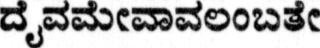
ದೈವಮೇವಾವಲಂಬತೇ
